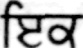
ਇਕ
